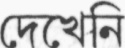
দেখেনি
